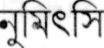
নুমিৎসি
